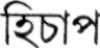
হিচাপ
